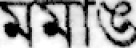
মমাঙ
